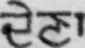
ਦੇਣਾ
